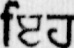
ਇਹ
